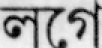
লগে
